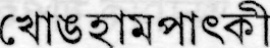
খোকঙহামপাৎকী
